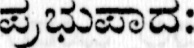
ಪ್ರಭುಪಾದ:
